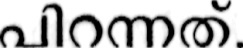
പിറന്നത്.
